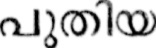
പുതിയ
